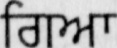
ਗਿਆ
